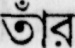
তাঁর
